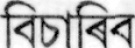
বিচাৰিব
